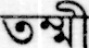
তম্মী
